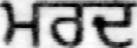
ਮਰਦ
